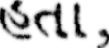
હતા,
